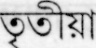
তৃতীয়া
